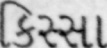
કિસ્સા
